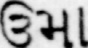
ઉમા
